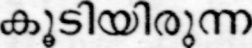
കൂടിയിരുന്ന
